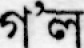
গ'ল
